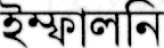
ইম্ফালনি
